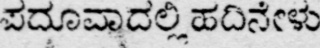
ಪದೂವಾದಲ್ಲಿಹದಿನೇಳು
